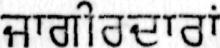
ਜਾਗੀਰਦਾਰਾਂ
